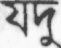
যদু
